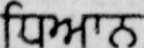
ਧਿਆਨ
